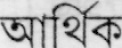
আর্থিক
